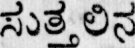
ಸುತ್ತಲಿನ
